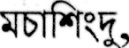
মচাশিংদু,
